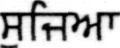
ਸੁਜਿਆ
